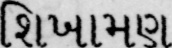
શિખામણ
